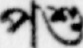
পশু
